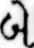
બે
